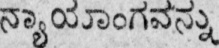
ನ್ಯಾಯಾಂಗವನ್ನು
